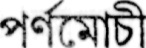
পর্ণমোচী
